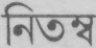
নিতম্ব
